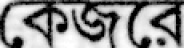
কেজরে
